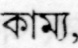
কাম্য,
